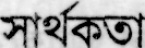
সার্থকতা
